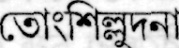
তোংশিল্লুদনা
